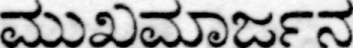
ಮುಖಮಾರ್ಜನ
